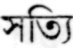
সত্যি
